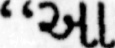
"આ
